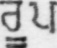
ਰੂਪ
